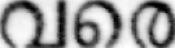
വരെ
